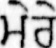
ਮੇਰੇ
